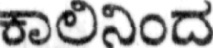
ಕಾಲಿನಿ೦ದ
